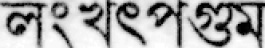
লংখৎপগুম
